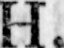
H.
